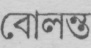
বোলন্ত
